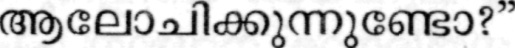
ആലോചിക്കുന്നുണ്ടോ?"
